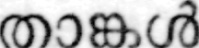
താങ്കള്‍
